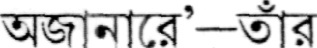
অজানারে’–তাঁর
